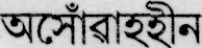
অসোঁৱাহহীন
